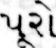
પૂરો
